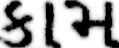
કામ
